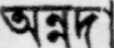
অন্নদা
